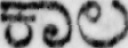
ಕಾಲ
